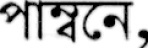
পাম্বনে,
